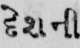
દેશની
